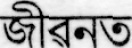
জীৱনত
